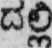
ದಲ್ಲಿ
